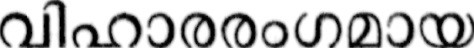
വിഹാരരംഗമായ
